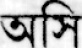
অসি
